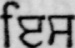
ਇਸ
